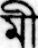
মী
